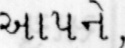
આપને,
